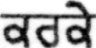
ਕਰਕੇ
